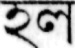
হল
